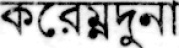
করেম্নদুনা
